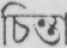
চিন্তা
